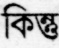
কিন্তু
